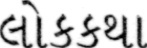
લોકકથા
